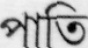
পাতি
